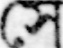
সে
